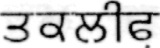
ਤਕਲੀਫ਼
